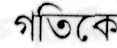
গতিকে
